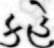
કહે
